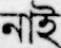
নাই
